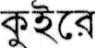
কুইরে
